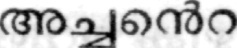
അച്ചന്റെ
